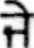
ਜੇ
